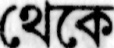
থেকে
